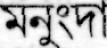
মনুংদা
